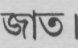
জাত
